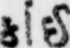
કાંઈ
